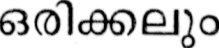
ഒരിക്കലും
